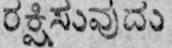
ರಕ್ಷಿಸುವುದು
